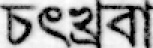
চৎখ্রবা
